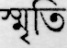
স্মৃতি
